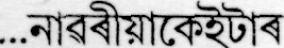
..নাৱৰীয়াকেইটাৰ
